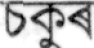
চকুৰ
